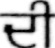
ਦੀ
